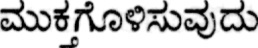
ಮುಕ್ತಗೊಳಿಸುವುದು
